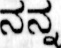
ನನ್ನ
